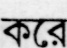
করে
